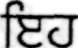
ਇਹ
